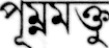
পূম্নমক্তু
